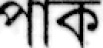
পাক
